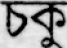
চকু
